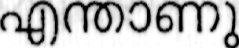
എന്താണു
